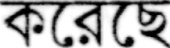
করেছে
